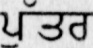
ਪੁੱਤਰ
